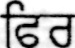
ਫਿਰ
